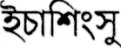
ইচাশিংসু
